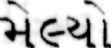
મેલ્યો
